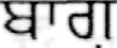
ਬਾਗ਼
